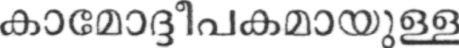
കാമോദ്ദീപകമായുള്ള
